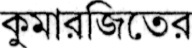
কুমারজিতের
